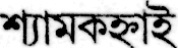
শ্যামকহ্ণাই
